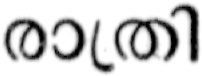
രാത്രി
